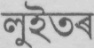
লুইতৰ
